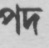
পদ
